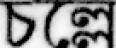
চল্লে
